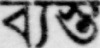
ব্যস্ত
